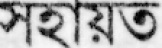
সহায়ত
